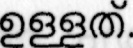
ഉള്ളത്.
